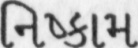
નિષ્કામ
